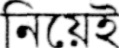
নিয়েই
